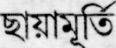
ছায়ামূর্তি
